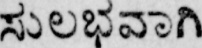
ಸುಲಭವಾಗಿ
